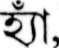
হ্যাঁ,
